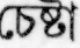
চেষ্টা
